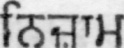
ਨਿਜ਼ਾਮ
